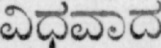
ವಿಧವಾದ
